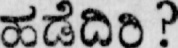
ಹಡೆದಿರಿ?
